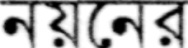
নয়নের
